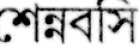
শেন্নবসি
